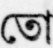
তো
